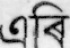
এৰি
